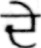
ਦੇ
